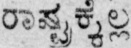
ರಾಷ್ಟ್ರಕ್ಕೆಲ್ಲ
